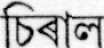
চিৰাল
